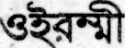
ওইরম্মী
